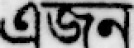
এজন
